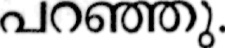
പറഞ്ഞു.
